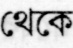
থেকে
